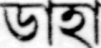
ডাহা
